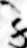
કે
